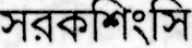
সরকশিংসি
